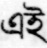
এই
